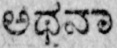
ಅಥವಾ
